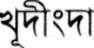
খূদীংদা
